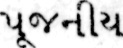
પૂજનીય
